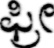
ಫ್ರೀ
